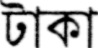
টাকা
